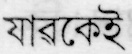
যাৱকেই
